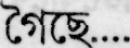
গৈছে....
